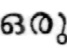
ഒരു
